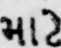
બીજાંને
